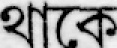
থাকে
